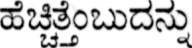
ಹೆಚ್ಚಿತ್ತೆಂಬುದನ್ನು
